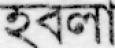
হবলা
